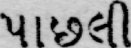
પાછલી
